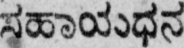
ಸಹಾಯಧನ
